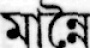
মান্নৈ
